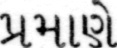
પ્રમાણે
